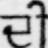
ਦੀ
